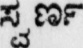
ಸ್ವರ್ಣ
